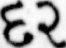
દર
